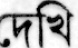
দেখি
